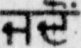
ਜਦੋਂ
